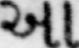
આ
